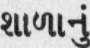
શાળાનું
